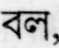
বল,
